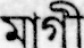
মাগী
